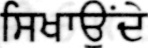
ਸਿਖਾਉਂਦੇ
